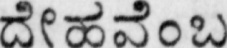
ದೇಹವೆಂಬ
